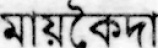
মায়কৈদা
